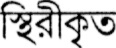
স্থিরীকৃত
